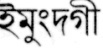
ইমুংদগী
